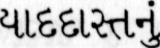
યાદદાસ્તનું
